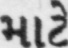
માટે
